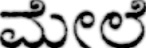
ಮೇಲೆ
